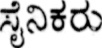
ಸೈನಿಕರು
